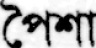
পৈশা
